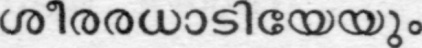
ശീരരധാടിയേയും
